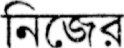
নিজের
